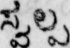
ಸ್ವಲ್ಪ
